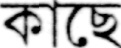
কাছে
